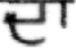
ਦਾ
